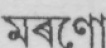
মৰণো
